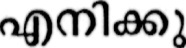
എനിക്കു
